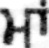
ਮਾਂ
